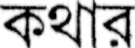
কথার
